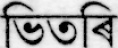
ভিতৰি
